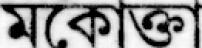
মকোক্তা
